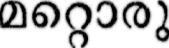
മറ്റൊരു
